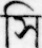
সি
